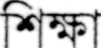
শিক্ষা
